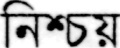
নিশ্চয়
